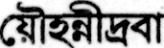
য়ৌহন্নীদ্রবা
